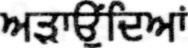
ਅੜਾਉਂਦਿਆਂ
